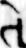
તે
